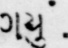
ગયું.
